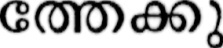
ത്തേക്കു
